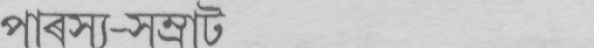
পাৰস্য-সম্ৰাট
